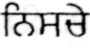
ਨਿਸਚੇ
